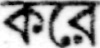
করে
